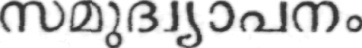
സമുദ്വ്യാപനം
